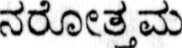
ನರೋತ್ತಮ
